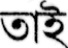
তাই
